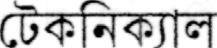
টেকনিক্যাল
